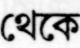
থেকে
